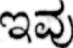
ಇವು
